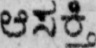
ಆಸಕ್ತಿ
